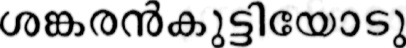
ശങ്കരന്‍കുട്ടിയോടു
